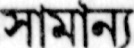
সামান্য
